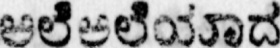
ಅಲೆಅಲೆಯಾದ
